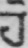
ਹੋ
